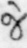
જે
